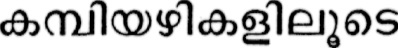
കമ്പിയഴികളിലൂടെ
